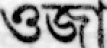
ওজা
